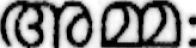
അമ്മ:
